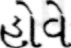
હોવે
